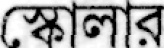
স্কোলার
